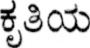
ಕೃತಿಯ
